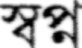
স্বপ্ন
